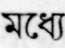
মধ্যে
